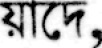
য়াদে,
